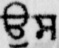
ਉਸ
